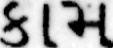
કામ
